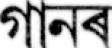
গানৰ
